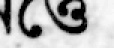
নত্তে
